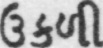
ઉકળી
